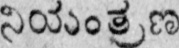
ನಿಯಂತ್ರಣ
